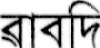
ৱাবদি
